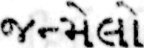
જન્મેલો
